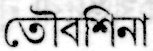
লৌবশিনা
